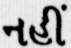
નહીં
